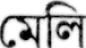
মেলি
